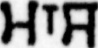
ਮਾਸ
